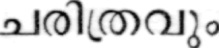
ചരിത്രവും
